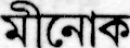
মীনোক
